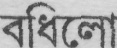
বধিলো
